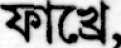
ফাখ্রে,
